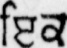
ਇਕ
